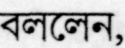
বললেন,
